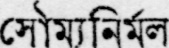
সৌম্যনির্মল
